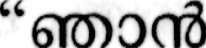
“ഞാന്‍
